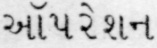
ઑપરેશન
